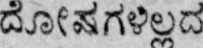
ದೋಷಗಳಿಲ್ಲದ
